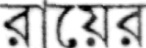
রায়ের
